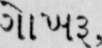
ગોખરૂ,
